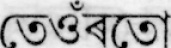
তেওঁৰতো
